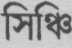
সিঞ্চি
